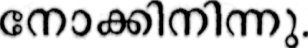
നോക്കിനിന്നു.
